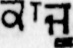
ਕਾਜੂ
